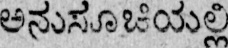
ಅನುಸೂಚಿಯಲ್ಲಿ
